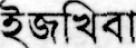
ইজখিবা
